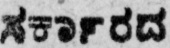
ಸರ್ಕಾರದ
